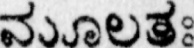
ಮೂಲತಃ
